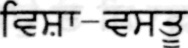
ਵਿਸ਼ਾ-ਵਸਤੂ
